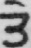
ਤੇ
